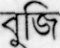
বুজি
